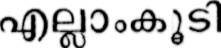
എല്ലാംകൂടി
